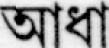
আধা
